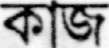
কাজ
